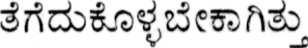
ತೆಗೆದುಕೊಳ್ಳಬೇಕಾಗಿತ್ತು
